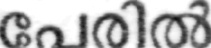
പേരില്‍
